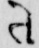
તે
